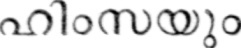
ഹിംസയും
